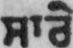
ਸਾਰੇ
